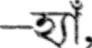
-হ্যাঁ,
